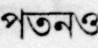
পতনও
